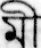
মী
